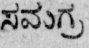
ಸಮಗ್ರ
